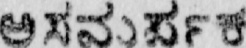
ಅಸಮರ್ಪಕ
